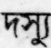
দস্যু
